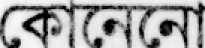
কোনেনো
